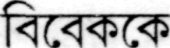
বিবেককে
